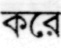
করে
